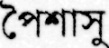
পৈশাসু
